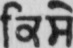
ਕਿਸੇ
